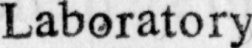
Laboratory
